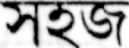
সহজ
